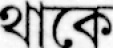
থাকে
